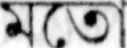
মতো
